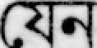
যেন
